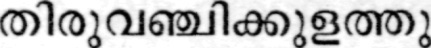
തിരുവഞ്ചിക്കുളത്തു
